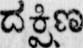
ದಕ್ಷಿಣ
